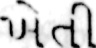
ખેતી
